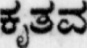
ಕೃತವ
